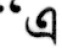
“এ
